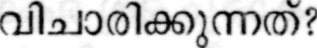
വിചാരിക്കുന്നത്?
